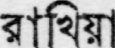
রাখিয়া
